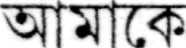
আমাকে
